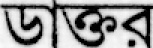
ডাক্তর
